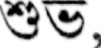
শুভ,
